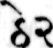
ઠેર
